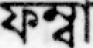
ফম্বা
